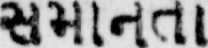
સમાનતા
